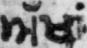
ਅੱਖਾਂ
